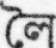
লৈ
